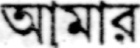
আমার
